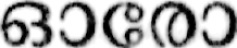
ഓരോ
